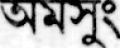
অমসুং
